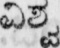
ವಿಶ್ವ
